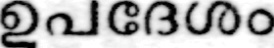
ഉപദേശം
